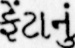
ફેંટાનું
